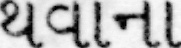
થવાના
